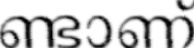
ണ്ടാണ്
